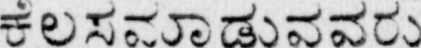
ಕೆಲಸಮಾಡುವವರು
